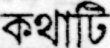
কথাটি
